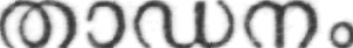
താഡനം
